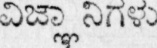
ವಿಜ್ಞಾನಿಗಳು
